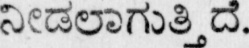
ನೀಡಲಾಗುತ್ತಿದೆ.
